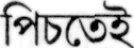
পিচতেই
